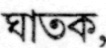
ঘাতক,
